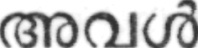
അവള്‍
